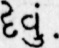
દેવું.
